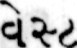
વેસ્ટ
